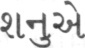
શનુએ
